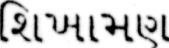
શિખામણ
